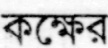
কক্ষের
